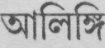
আলিঙ্গি
